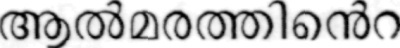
ആല്‍മരത്തിന്റെ
